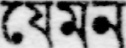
যেমন
